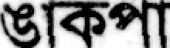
ঙাকপা
